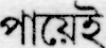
পায়েই
